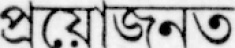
প্রয়োজনত
